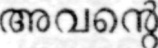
അവന്റെ
